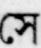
সে
